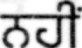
ਨਹੀਂ
